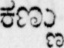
ಕಣ್ಣು
